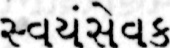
સ્વયંસેવક
